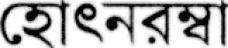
হোৎনরম্বা
